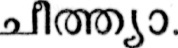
ചീത്ത്യാ.
